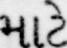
માટે
